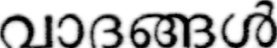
വാദങ്ങള്‍
